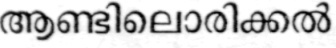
ആണ്ടിലൊരിക്കല്‍
